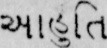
આહુતિ
